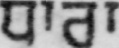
ਧਾਰਾ
